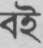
বই
